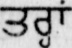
ਤਰ੍ਹਾਂ
